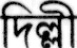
দিল্লী
